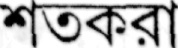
শতকরা
